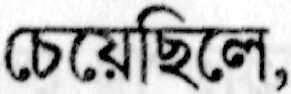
চেয়েছিলে,
